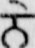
ਨੇ
